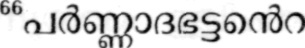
66പര്‍ണ്ണാദഭട്ടന്റെ
